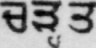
ਚੜ੍ਹਤ
